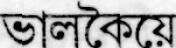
ভালকৈয়ে
